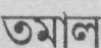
তমাল
